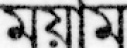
ময়াম
